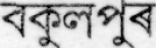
বকুলপুৰ
